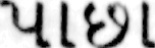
પાછા
